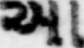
આ
